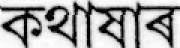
কথাষাৰ
